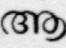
ആ
